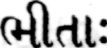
ભીતાઃ
